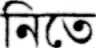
নিতে
